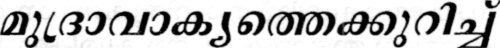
മുദ്രാവാക്യത്തെക്കുറിച്ച്
